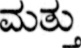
ಮತ್ತು
